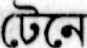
টেনে
